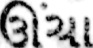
ઊંચા
